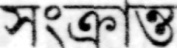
সংক্রান্ত
